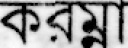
করম্না
